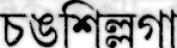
চঙশিল্লগা
